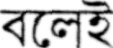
বলেই
